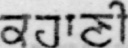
ਕਹਾਣੀ
